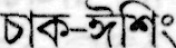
চাক-ঈশিং
